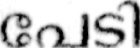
പേടി
